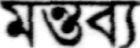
মন্তব্য
